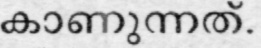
കാണുന്നത്.
